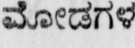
ಮೋಡಗಳ
